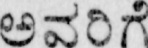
ಅವರಿಗೆ
